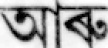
আৰু
